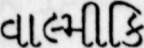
વાલ્મીકિ
